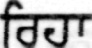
ਰਿਹਾ
